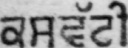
ਕਸਵੱਟੀ
